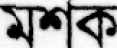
মশক
